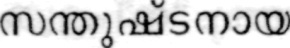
സന്തുഷ്ടനായ
